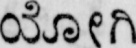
ಯೋಗಿ
